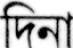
দিনা
